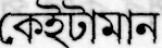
কেইটামান
